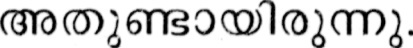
അതുണ്ടായിരുന്നു.
